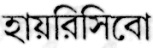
হায়রিসিবো
